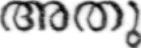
അതു
